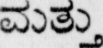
ಮತ್ತು
